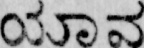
ಯಾವ
